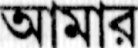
আমার
